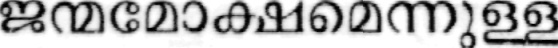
ജന്മമോക്ഷമെന്നുള്ള
